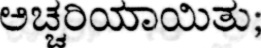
ಅಚ್ಚರಿಯಾಯಿತು;
